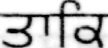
ਤਾਕਿ
